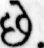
છે.
